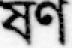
ষণ
